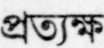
প্রত্যক্ষ
